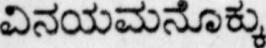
ವಿನಯಮನೊಕ್ಕು
